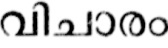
വിചാരം
